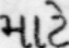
માટે
